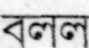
বলল
